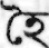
হৈ
